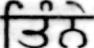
ਤਿੰਨੇ
